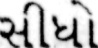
સીધો
